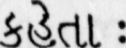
કહેતાઃ
